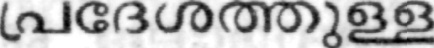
പ്രദേശത്തുള്ള
